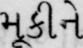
મૂકીને
